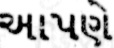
આપણે
